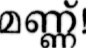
മണ്ണ്!
